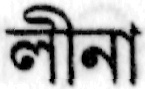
লীনা
